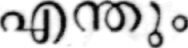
എന്തും
